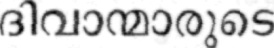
ദിവാന്മാരുടെ
